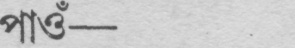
পাওঁ-
